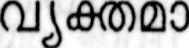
വ്യക്തമാ
